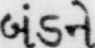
બંડને
